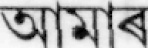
আমাৰ
